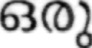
ഒരു
